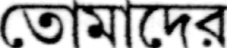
তোমাদের
